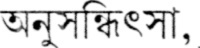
অনুসন্ধিত্সা,
